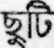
ছুটি
